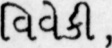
વિવેકી,
